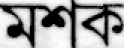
মশক
